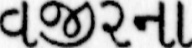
વજીરના
